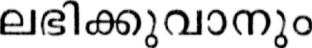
ലഭിക്കുവാനും
